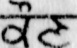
ਕੌਣ
